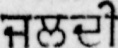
ਜਲਦੀ
